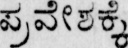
ಪ್ರವೇಶಕ್ಕೆ
